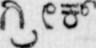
ಗ್ರೀಕ್
